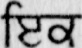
ਇਕ
